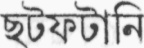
ছটফটানি
